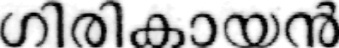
ഗിരികായന്‍
